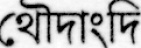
থৌদাংদি
